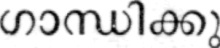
ഗാന്ധിക്കു
